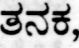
ತನಕ,
